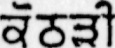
ਕੋਠੜੀ
